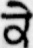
ਕੇ
